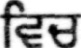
ਵਿਚ
